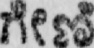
ಗೇಣಿ
